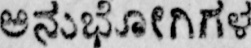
ಅನುಭೋಗಿಗಳ
